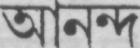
আনন্দ
